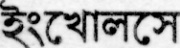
ইংখোলসে
